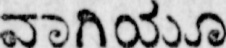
ವಾಗಿಯೂ
